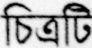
চিত্রটি
